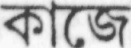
কাজে
